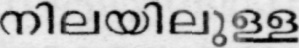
നിലയിലുള്ള
